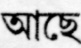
আছে
